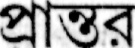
প্রান্তর
